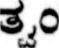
ತ್ವಂ
